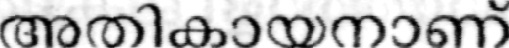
അതികായനാണ്
